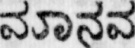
ಮಾನವ
